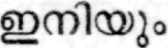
ഇനിയും
